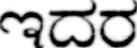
ಇದರ
